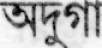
অদুগা
